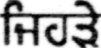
ਜਿਹੜੇ
